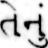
તેનું
